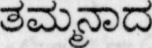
ತಮ್ಮನಾದ
